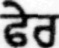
ਫੇਰ
